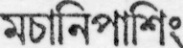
মচানিপাশিং
